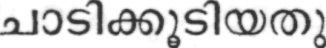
ചാടിക്കൂടിയതു
